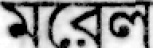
মরেল
